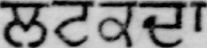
ਲਟਕਦਾ
